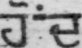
ਹੋਂਦ
